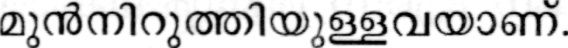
മുന്‍നിറുത്തിയുള്ളവയാണ്.
